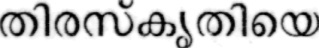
തിരസ്കൃതിയെ
